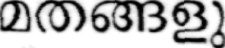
മതങ്ങളു
